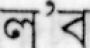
ল'ব
